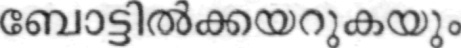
ബോട്ടില്‍ക്കയറുകയും
